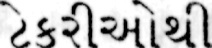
ટેકરીઓથી
